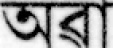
অৱা
